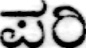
ಪರಿ
